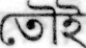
তৌই
